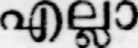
എല്ലാ
